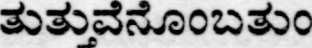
ತುತ್ತುವೆನೊಂಬತುಂ
